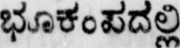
ಭೂಕಂಪದಲ್ಲಿ
